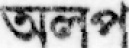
অলপ
